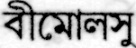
বীমোলসু
